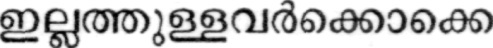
ഇല്ലത്തുള്ളവര്‍ക്കൊക്കെ
